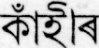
কাঁহীৰ
